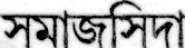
সমাজসিদা
